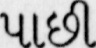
પાછી
